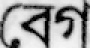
বেগ
